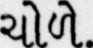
ચોળે.
